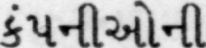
કંપનીઓની
